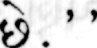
છે."
